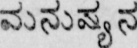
ಮನುಷ್ಯನ
